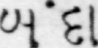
બંદા
